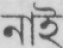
নাই
